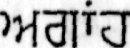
ਅਗਾਂਹ
